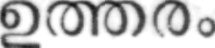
ഉത്തരം
